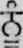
ਨੂੰ
